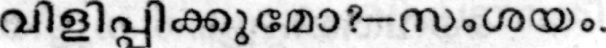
വിളിപ്പിക്കുമോ?-സംശയം.
